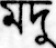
মদু
